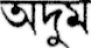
অদুম
